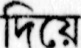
দিয়ে
